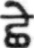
ਛੇ
